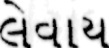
લેવાય
